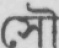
সৌ
